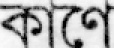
কাণে
